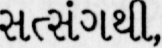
સત્સંગથી,
